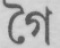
গৈ
